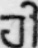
ਹੀ
